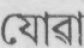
যোৱা
